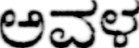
ಅವಳ
